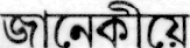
জানেকীয়ে
